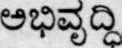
ಅಭಿವೃದ್ಧಿ
